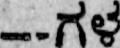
--ಗಳಯ
